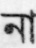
না
